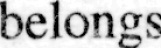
belongs
